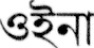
ওইনা
